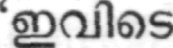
‘ഇവിടെ
